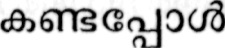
കണ്ടപ്പോള്‍
